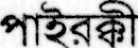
পাইরক্কী
